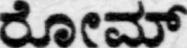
ರೋಮ್
